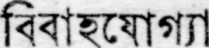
বিবাহযোগ্যা
